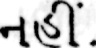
નહીં.
